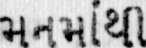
મનમાંથી
